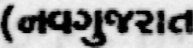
(નવગુજરાત
